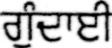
ਗੁੰਦਾਈ
